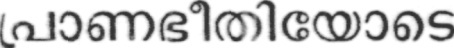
പ്രാണഭീതിയോടെ
